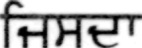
ਜਿਸਦਾ
